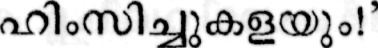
ഹിംസിച്ചുകളയും!'
